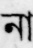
না
